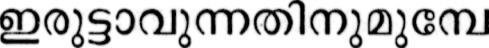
ഇരുട്ടാവുന്നതിനുമുമ്പേ
